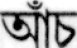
আঁচ
